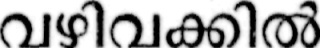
വഴിവക്കില്‍
